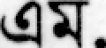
এম.
